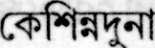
কেশিন্নদুনা
